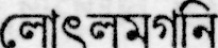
লোৎলমগনি
